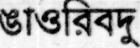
ঙাওরিবদু
